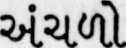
અંચળો
